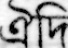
ঐদি
